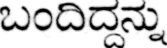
ಬಂದಿದ್ದನ್ನು
